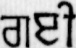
ਗਈ
